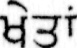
ਖੇਤਾਂ
